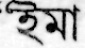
“ইমা
